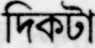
দিকটা
